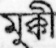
মুক্কী
